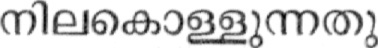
നിലകൊള്ളുന്നതു
